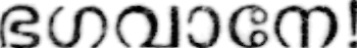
ഭഗവാനേ!
